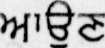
ਆਉਣ
